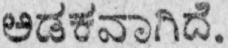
ಅಡಕವಾಗಿದೆ.
